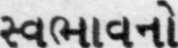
સ્વભાવનો
